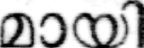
മായി
